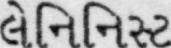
લેનિનિસ્ટ
